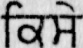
ਕਿਸੇ
